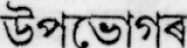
উপভোগৰ
